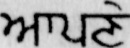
ਆਪਣੇ
